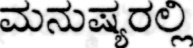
ಮನುಷ್ಯರಲ್ಲಿ
